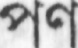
পণ
